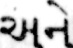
અને
